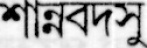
শান্নবদসু
